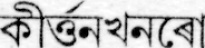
কীর্ত্তনখনৰো
